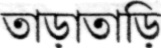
তাড়াতাড়ি
